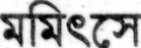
মমিৎসে
